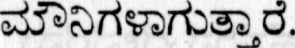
ಮೌನಿಗಳಾಗುತ್ತಾರೆ.
